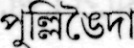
পুল্লিঙৈদা
